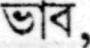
ভাব,
